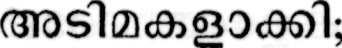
അടിമകളാക്കി;
